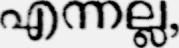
എന്നല്ല,
